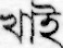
খাই
